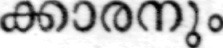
ക്കാരനും
